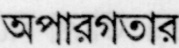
অপারগতার
